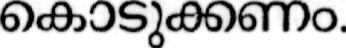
കൊടുക്കണം.
